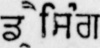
ਡ੍ਰੈਸਿੰਗ
